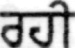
ਰਹੀ
